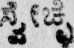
ಸ್ವೇಚ್ಛೆ
